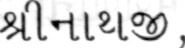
શ્રીનાથજી,
